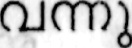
വന്നു
